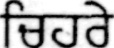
ਚਿਹਰੇ
